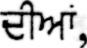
ਦੀਆਂ,
